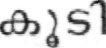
കൂടി
